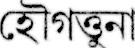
হৌগত্তুনা
